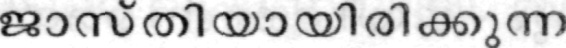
ജാസ്തിയായിരിക്കുന്ന
